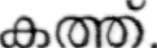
കത്ത്.
